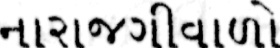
નારાજગીવાળો
